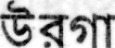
উরগা
